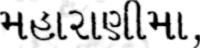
મહારાણીમા,
